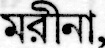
মরীনা,
